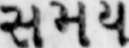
સમય
